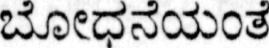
ಬೋಧನೆಯಂತೆ
